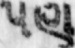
પણ
